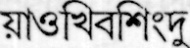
য়াওখিবশিংদু
